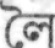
লৈ
